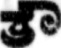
ತೌ
